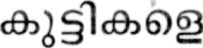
കുട്ടികളെ
